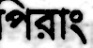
পিরাং
